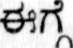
ಈಗ್ಗೆ
